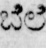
ಬೆಲೆ
